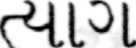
ત્યાગ
